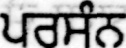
ਪਰਸੰਨ
